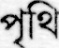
পৃথি
